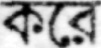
করে
